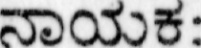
ನಾಯಕ:
